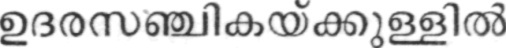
ഉദരസഞ്ചികയ്ക്കുള്ളില്‍
